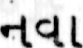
નવા
